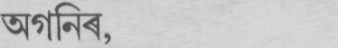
অগনিৰ,
